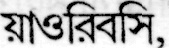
য়াওরিবসি,
